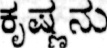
ಕೃಷ್ಣನು
